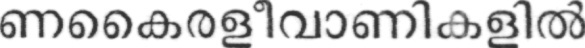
ണകൈരളീവാണികളില്‍
